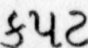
કપટ
